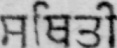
ਸਥਿਤੀ
